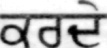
ਕਰਦੇ
